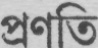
প্ৰণতি
